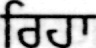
ਰਿਹਾ
